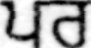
ਪਰ
